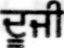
ਦੂਜੀ
